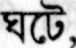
ঘটে,
